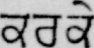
ਕਰਕੇ
